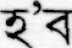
হ'ব
